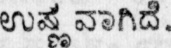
ಉಷ್ಣವಾಗಿದೆ.
